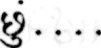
છું....
